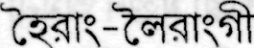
হৈরাং-লৈরাংগী
